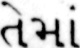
તેમાં
